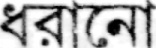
ধরানো
